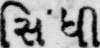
સિંધી
